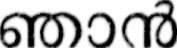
ഞാന്‍
